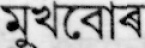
মুখবোৰ
